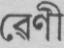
ৱেণী
